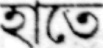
হাতে
